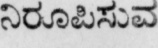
ನಿರೂಪಿಸುವ
